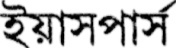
ইয়াসপার্স
